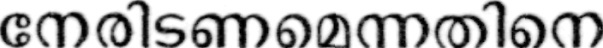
നേരിടണമെന്നതിനെ
